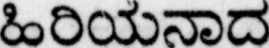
ಹಿರಿಯನಾದ
